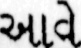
આવે
